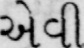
એવી
